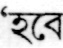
‘হবে
